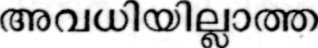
അവധിയില്ലാത്ത
